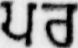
ਪਰ
